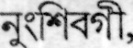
নুংশিবগী,
